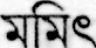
মমিৎ
